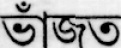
ভাঁজত
